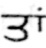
ਤਾਂ
